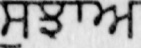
ਸੁਝਾਅ
